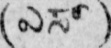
(ಎಸ್)
